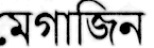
মেগাজিন
